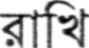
রাখি
